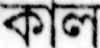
কাল
